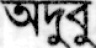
অদুবু
